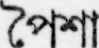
পৈশা
